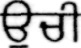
ਉਚੀ
